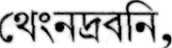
থেংনদ্রবনি,
